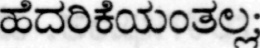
ಹೆದರಿಕೆಯಂತಲ್ಲ;
